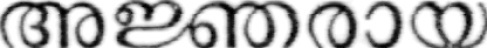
അജ്ഞരായ
